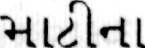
માટીના
